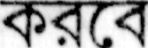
করবে
